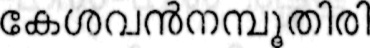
കേശവന്‍നമ്പൂതിരി
